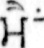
ਮੈਂ
